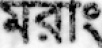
মরাং
